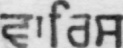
ਵਾਰਿਸ
